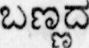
ಬಣ್ಣದ
